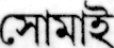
সোমাই
